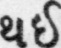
થઈ
